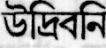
উদ্রিবনি
